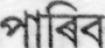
পাৰিব
